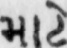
માટે
